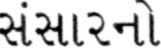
સંસારનો
